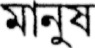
মানুষ
